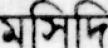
মসিদি
